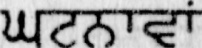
ਘਟਨਾਵਾਂ
